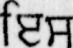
ਇਸ
